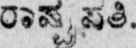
ರಾಷ್ಟ್ರಪತಿ.
